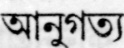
আনুগত্য
